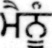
ਮੈਨੂੰ
